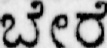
ಬೇರೆ
